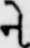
ને
